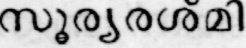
സൂര്യരശ്മി
